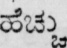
ಹೆಚ್ಚು
